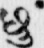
છું
